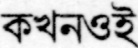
কখনওই
